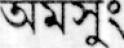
অমসুং
